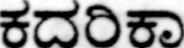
ಕದರಿಕಾ
